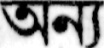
অন্য
